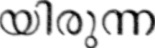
യിരുന്ന
